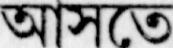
আসতে
